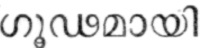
ഗൂഢമായി
